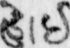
હોઈ
